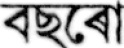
বছৰো
